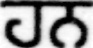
ਹਨ
